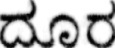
ದೂರ
